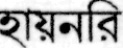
হায়নরি
